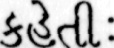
કહેતી:
